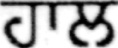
ਹਾਲ
